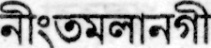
নীংতমলানগী
